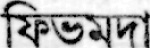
ফিভমদা
